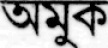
অমুক
